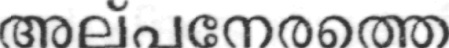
അല്പനേരത്തെ
